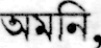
অমনি,
